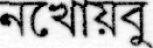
নখোয়বু
